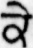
ਕੇ
